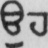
ਉਹ
